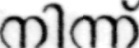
നിന്ന്
